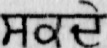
ਸਕਦੇ
